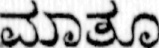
ಮಾತೂ
